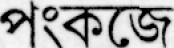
পংকজে
